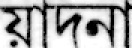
য়াদনা
